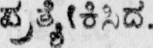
ಪ್ರತ್ಯೇಕಿಸಿದ.
